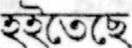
হইতেছে
